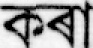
কৰা
